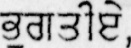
ਭੁਗਤੀਏ,
